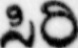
ಸಿರಿ
